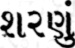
શરણું
